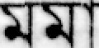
মমা
